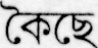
কৈছে
